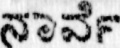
ನಾರ್ವೆ
